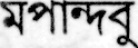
মপান্দবু
